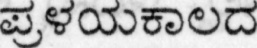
ಪ್ರಳಯಕಾಲದ
